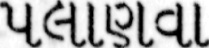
પલાણવા
